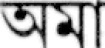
অমা
